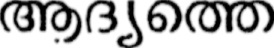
ആദ്യത്തെ
